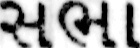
સભા
